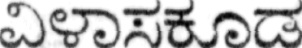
ವಿಳಾಸಕೂಡ
